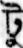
টু
